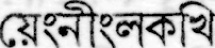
য়েংনীংলকখি
